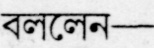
বললেন–
